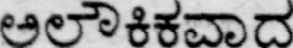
ಅಲೌಕಿಕವಾದ
